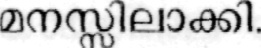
മനസ്സിലാക്കി.
